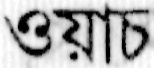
ওয়াচ
